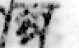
গল্প
